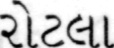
રોટલા
